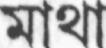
মাথা
